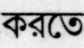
করতে
